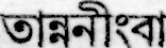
তান্ননীংবা
